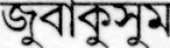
জুবাকুসুম
